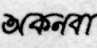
অকনবা
